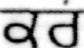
ਕਰ
